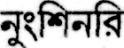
নুংশিনরি
